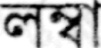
লম্বা
